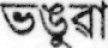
ভঙুৱা
